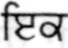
ਇਕ
